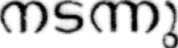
നടന്നു
